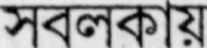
সবলকায়
